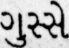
ગુસ્સે
